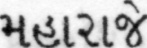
મહરાજે
